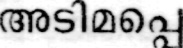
അടിമപ്പെ
